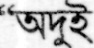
“অদুই
